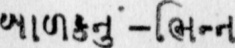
બાળકનું-ભિન્ન
